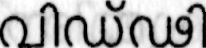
വിഡ്ഢി
